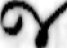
જ
